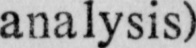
analysis)
